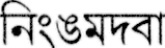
নিংঙমদবা
